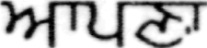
ਆਪਣਾ
